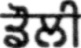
ਡੌਲੀ
